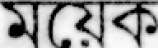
ময়েক
